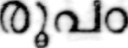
രൂപം
